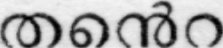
തന്റെ
